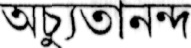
অচ্যুতানন্দ
